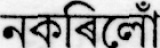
নকৰিলোঁ
